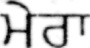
ਮੇਰਾ
